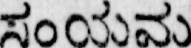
ಸಂಯಮ
